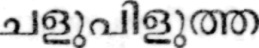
ചളുപിളുത്ത
